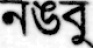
নঙবু
